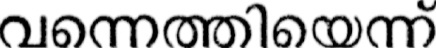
വന്നെത്തിയെന്ന്
